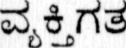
ವ್ಯಕ್ತಿಗತ
